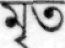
মৃত
